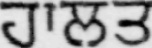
ਹਾਲਤ
